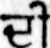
ਦੀ
